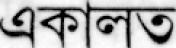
একালত
